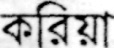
করিয়া
